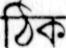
ঠিক
